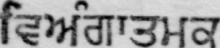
ਵਿਅੰਗਾਤਮਕ
